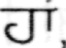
ਹਾਂ,
